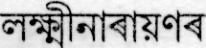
লক্ষ্মীনাৰায়ণৰ
